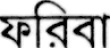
ফরিবা
